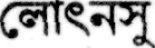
লোৎনসু
